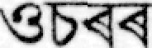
ওচৰৰ
